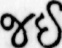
જઈ
